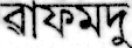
ৱাফমদু
